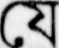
যে
